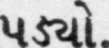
પડ્યો.
